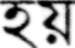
হয়
